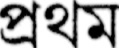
প্রথম
